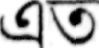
এত
